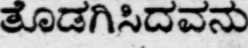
ತೊಡಗಿಸಿದವನು
